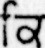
ਕਿ
